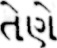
તેણે
